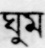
ঘুম
